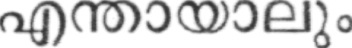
എന്തായാലും
